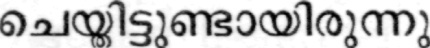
ചെയ്തിട്ടുണ്ടായിരുന്നു
